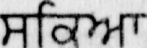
ਸਕਿਆ
